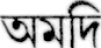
অমদি
